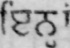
ਇਨ੍ਹਾਂ
